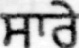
ਸਾਰੇ
